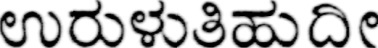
ಉರುಳುತಿಹುದೀ
